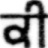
ਕੀ
